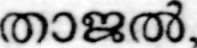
താജല്‍,
